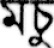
মচু
